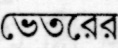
ভেতরের
